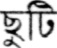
ছুটি
